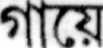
গায়ে
